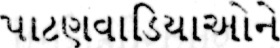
પાટણવાડિયાઓને
